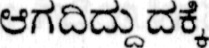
ಆಗದಿದ್ದುದಕ್ಕೆ
